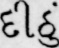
દીઠું
